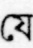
যে
